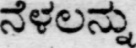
ನೆಳಲನ್ನು
